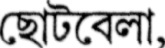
ছোটবেলা,
